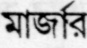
মার্জার
